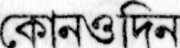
কোনওদিন
